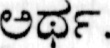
ಅರ್ಥ.
